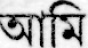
আমি
